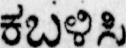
ಕಬಳಿಸಿ
